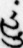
હું
